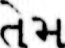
તેમ
